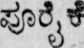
ಪೂರೈಕೆ
